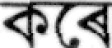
কৰে
